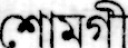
শোমগী
